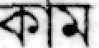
কাম
